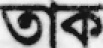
তাক
